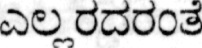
ಎಲ್ಲರದರಂತೆ
